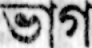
ভাগ
